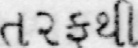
તરફથી
